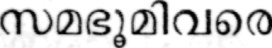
സമഭൂമിവരെ
